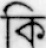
কি
